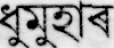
ধুমুহাৰ
